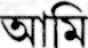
আমি
